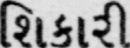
શિકારી
